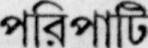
পরিপাটি
